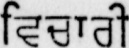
ਵਿਚਾਰੀ
